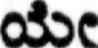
ಯೇ
